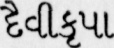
દૈવીકૃપા
